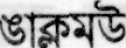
ঙাক্লমউ
